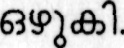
ഒഴുകി.
